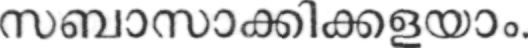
സബാസാക്കിക്കളയാം.
